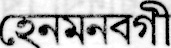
হেনমনবগী
